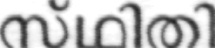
സ്ഥിതി
